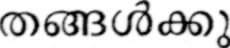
തങ്ങള്‍ക്കു
